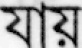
যায়
